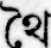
থৈ
